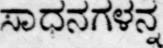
ಸಾಧನಗಳನ್ನ
